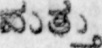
ಮತ್ತು
